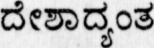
ದೇಶಾದ್ಯಂತ
